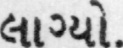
લાગ્યો.
